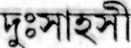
দুঃসাহসী
